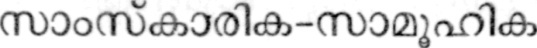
സാംസ്കാരിക-സാമൂഹിക
